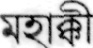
মহাক্কী
